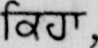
ਕਿਹਾ,
